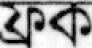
ফ্ৰক
